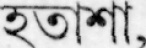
হতাশা,
